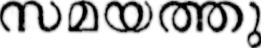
സമയത്തു
